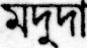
মদুদা
